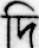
দি
